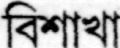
বিশাখা
